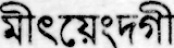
মীৎয়েংদগী
